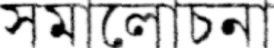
সমালোচনা
